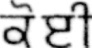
ਕੋਈ
